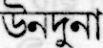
উনদুনা
